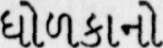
ધોળકાનો
